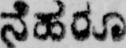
ನೆಹರೂ
